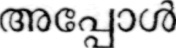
അപ്പോള്‍
